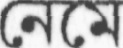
নেমে
